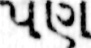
પણ
